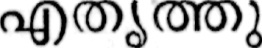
എതൃത്തു
